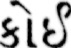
કોઈ
